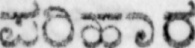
ಪರಿಹಾರ
